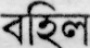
বহিল
